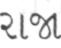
રાજા
